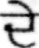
ਦੇ
